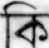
কি
